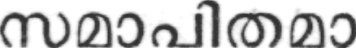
സമാപിതമാ
